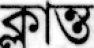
ক্লান্ত
